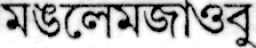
মঙলেমজাওবু
